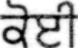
ਕੋਈ
